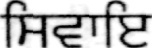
ਸਿਵਾਇ
